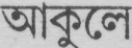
আকুলে
